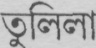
তুলিলা
